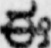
ಈ
